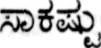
ಸಾಕಷ್ಟು
